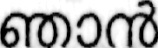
ഞാന്‍
